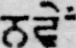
ਨਵੇਂ
